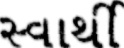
સ્વાર્થી
